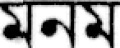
মনম
